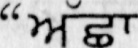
''ਅੱਛਾ
